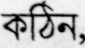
কঠিন,
